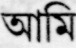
আমি
